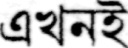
এখনই
